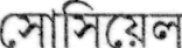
সোসিয়েল
